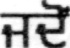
ਜਦੋਂ
